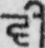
ਵੀ
